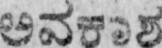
ಅವಕಾಶ
